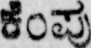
ಕೆಂಪು
